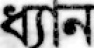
ধ্যান
